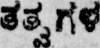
ತತ್ವಗಳ
